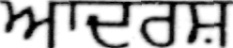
ਆਦਰਸ਼
